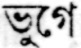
ভুগে
